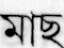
মাছ
